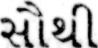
સૌથી
